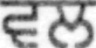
ਵਲ
